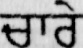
ਚਾਰੇ
